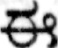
ಈ
